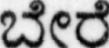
ಬೇರೆ
